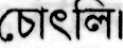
চোৎলি।
